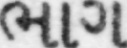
ભાગ
